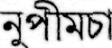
নুপীমচা
